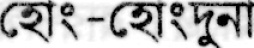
হোং-হোংদুনা
